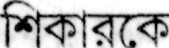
শিকারকে
